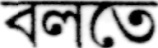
বলতে
